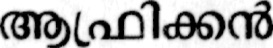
ആഫ്രിക്കന്‍
